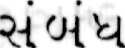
સંબંધ
